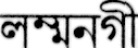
লম্মনগী
